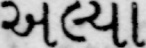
અલ્યા
